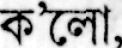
ক'লো,
